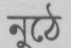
নুঠে
